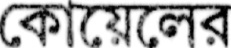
কোয়েলের
